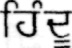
ਹਿੰਦੂ
